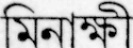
মিনাক্ষী
